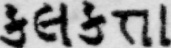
કલકત્તા
